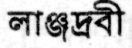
লাঞ্জদ্রবী
